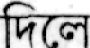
দিলে
